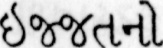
ઇજ્જતનો
